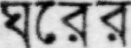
ঘরের
